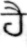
ਹੈ
